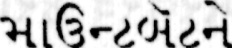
માઉન્ટબૅટને
